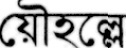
য়ৌহল্লে
